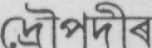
দ্ৰৌপদীৰ
